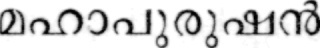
മഹാപുരുഷന്‍
